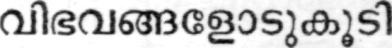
വിഭവങ്ങളോടുകൂടി
